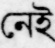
নেই
